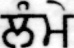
ਲੰਮੇ
